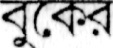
বুকের
